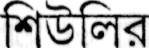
শিউলির
